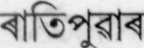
ৰাতিপুৱাৰ
